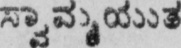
ಸ್ವಾಮ್ಯಯುತ
